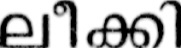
ലീക്കി
